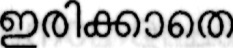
ഇരിക്കാതെ
